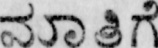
ಮಾತಿಗೆ
